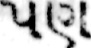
પણ
